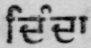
ਦਿੰਦਾ
